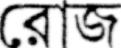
রোজ
